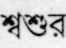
শ্বশুর
